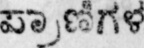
ಪ್ರಾಣಿಗಳ
